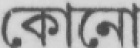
কোনো
